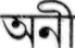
অনী
